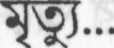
মৃত্যু...
